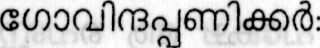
ഗോവിന്ദപ്പണിക്കര്‍:
